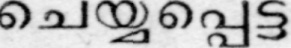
ചെയ്യപ്പെട്ട
